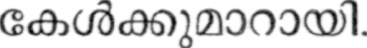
കേള്‍ക്കുമാറായി.
